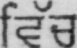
ਵਿੱਚ
